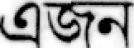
এজন
